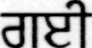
ਗਈ
